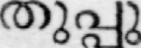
തുപ്പു
